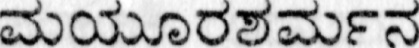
ಮಯೂರಶರ್ಮನ
